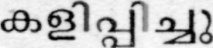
കളിപ്പിച്ചു
